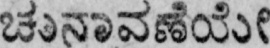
ಚುನಾವಣೆಯೇ
